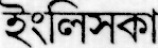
ইংলিসকা
